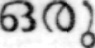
ഒരു
